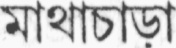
মাথাচাড়া
